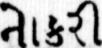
નોકરી
